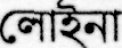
লোইনা
